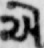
એ
